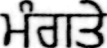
ਮੰਗਤੇ
